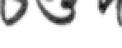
প্ৰচণ্ড
